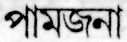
পামজনা
